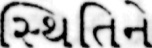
સ્થિતને
